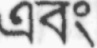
এবং
